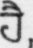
ਹੈ,
